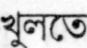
খুলতে
